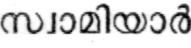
സ്വാമിയാര്‍
